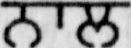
ਨਾਲ
